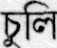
চুলি
